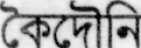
কৈদৌনি
